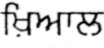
ਖ਼ਿਆਲ
